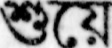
শুয়ে
